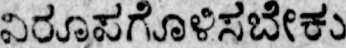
ವಿರೂಪಗೊಳಿಸಬೇಕು
